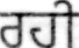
ਰਹੀ
